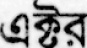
এক্টর
